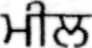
ਮੀਲ
